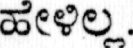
ಹೇಳಿಲ್ಲ.
